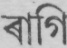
ৰাগি
